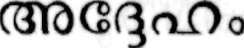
അദ്ദേഹം
